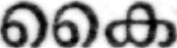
കൈ
